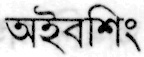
অইবশিং
